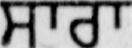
ਸਾਰਾ
